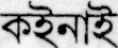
কইনাই
